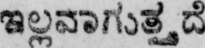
ಇಲ್ಲವಾಗುತ್ತದೆ
